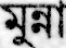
মুন্না
